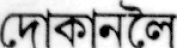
দোকানলৈ
